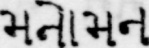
મનોમન
